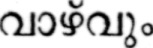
വാഴ്‌വും
